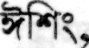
ঈশিং,
